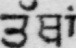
ਤੱਥਾਂ
